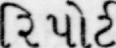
રિપોર્ટ
